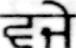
ਵਜੇ
